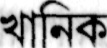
খানিক
